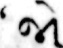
'જો
